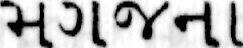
મગજના
